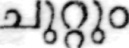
ചുറ്റും
